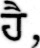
ਹੈ,
